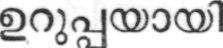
ഉറുപ്പയായി
